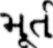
મૂર્ત
